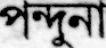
পন্দুনা
